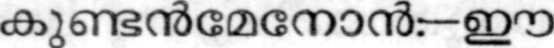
കുണ്ടന്‍മേനോന്‍:-ഈ
